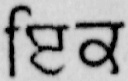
ਇਕ
